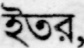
ইতর,
